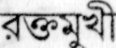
রক্তমুখী
